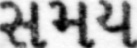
સમય
